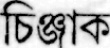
চিঞ্জাক
